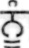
ਨੂੰ
